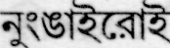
নুংঙাইরোই
